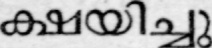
ക്ഷയിച്ചു
